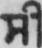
ਸੀ
